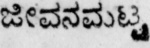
ಜೀವನಮಟ್ಟ
